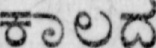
ಕಾಲದ
